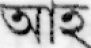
আহ
